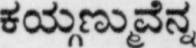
ಕಯ್ಗಣ್ಮುವೆನ್ನ
